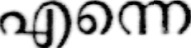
എന്നെ
